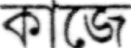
কাজে
